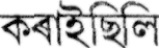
কৰাইছিলি
